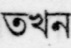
তখন
